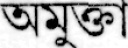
অমুক্তা
